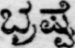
ಭ್ರಷ್ಟೆ
